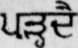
ਪੜ੍ਹਦੈ
